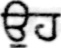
ਉਹ
